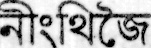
নীংথিজৈ
